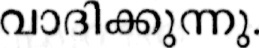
വാദിക്കുന്നു.
